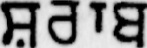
ਸ਼ਰਾਬ
